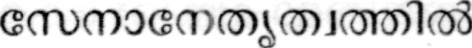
സേനാനേതൃത്വത്തില്‍
